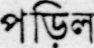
পড়িল
